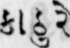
કાઠુરે
